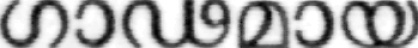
ഗാഢമായ
